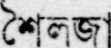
শৈলজা
